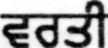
ਵਰਤੀ
